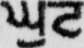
ਘੁਟ
